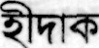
হীদাক
